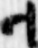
ન
